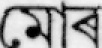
মোৰ
